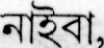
নাইবা,
